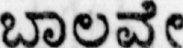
ಬಾಲವೇ
